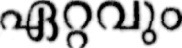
ഏറ്റവും
